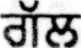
ਗੱਲ
